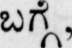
ಬಗ್ಗೆ,
